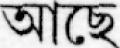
আছে
